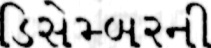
ડિસેમ્બરની
